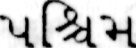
પશ્ચિમ
